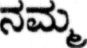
ನಮ್ಮ
